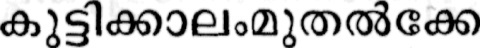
കുട്ടിക്കാലംമുതല്‍ക്കേ
